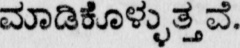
ಮಾಡಿಕೊಳ್ಳುತ್ತವೆ.
